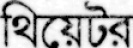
থিয়েটর
